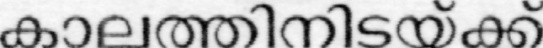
കാലത്തിനിടയ്ക്ക്
